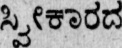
ಸ್ವೀಕಾರದ
